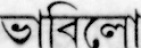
ভাবিলো
